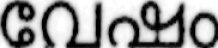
വേഷം
